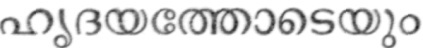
ഹൃദയത്തോടെയും
